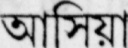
আসিয়া
